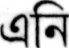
এনি
